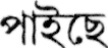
পাইছে
